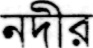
নদীর
